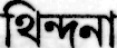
থিন্দনা
